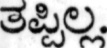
ತಪ್ಪಿಲ್ಲ.
